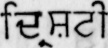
ਦ੍ਰਿਸ਼ਟੀ
